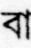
বা
